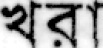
খরা
